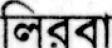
লিরবা
